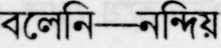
বলেনি–নন্দিয়
